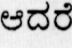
ಆದರೆ
